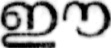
ഈ
